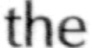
the
